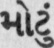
મોટું
